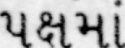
પક્ષમાં
